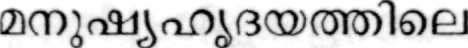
മനുഷ്യഹൃദയത്തിലെ
